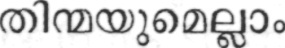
തിന്മയുമെല്ലാം
